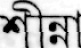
শীন্না
